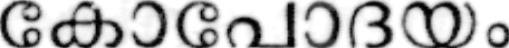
കോപോദയം
